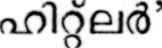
ഹിറ്റ്ലര്‍'
